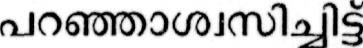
പറഞ്ഞാശ്വസിച്ചിട്ട്
